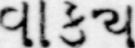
વાક્ય
